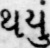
થયું
